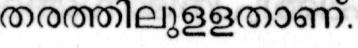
തരത്തിലുളളതാണ്.
